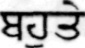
ਬਹੁਤੇ
